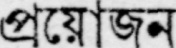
প্রয়োজন
